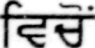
ਵਿਚੋਂ
